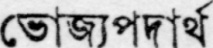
ভোজ্যপদার্থ
